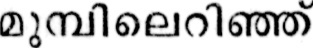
മുമ്പിലെറിഞ്ഞ്
